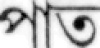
পাত
